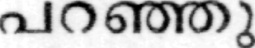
പറഞ്ഞു
